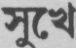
সুখে
